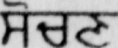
ਸੋਚਣ
